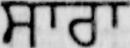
ਸਾਰਾ
